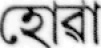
হোৱা
